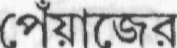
পেঁয়াজের
